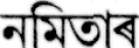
নমিতাৰ
